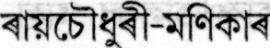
ৰায়চৌধুৰী-মণিকাৰ
